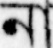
না
